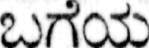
ಬಗೆಯ
